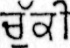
ਚੁੱਕੀ
